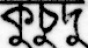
কুচুদু
